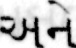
અને
